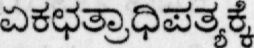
ಏಕಛತ್ರಾಧಿಪತ್ಯಕ್ಕೆ
